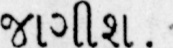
જાગીશ.
